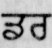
ਡਰ
